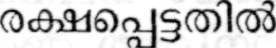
രക്ഷപ്പെട്ടതില്‍
